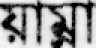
য়াম্না
